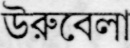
উরুবেলা
